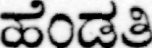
ಹೆಂಡತಿ
